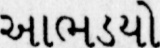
આભડયો
